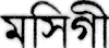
মসিগী
